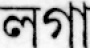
লগা
